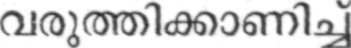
വരുത്തിക്കാണിച്ച്
